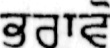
ਭਰਾਵੋ
